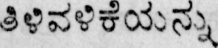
ತಿಳಿವಳಿಕೆಯನ್ನು
